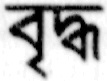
বৃদ্ধ
